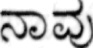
ನಾವು
